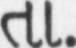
તા.
